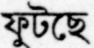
ফুটছে
